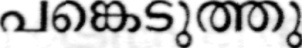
പങ്കെടുത്തു
